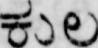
ಕುಲ
